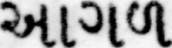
આગળ
